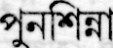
পুনশিন্না
